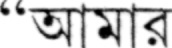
“আমার
